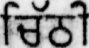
ਚਿੱਠੀ
